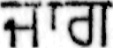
ਜਾਗ
